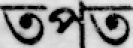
তপত
